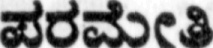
ಪರಮೇತಿ
